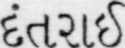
દંતરાઈ
